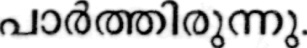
പാര്‍ത്തിരുന്നു.
